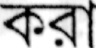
করা
